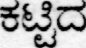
ಕಟ್ಟಿದ
